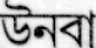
উনবা
